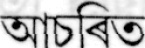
আচৰিত
